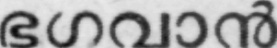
ഭഗവാന്‍
